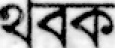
থবক
